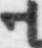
ન
